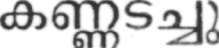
കണ്ണടച്ചു
